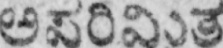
ಅಪರಿಮಿತ
